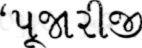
'પૂજારીજી
